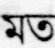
মত
